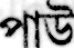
পাউ
